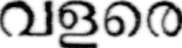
വളരെ
